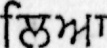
ਲਿਆ
